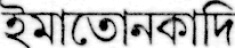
ইমাতোনকাদি
